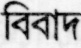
বিবাদ
